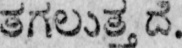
ತಗಲುತ್ತದೆ.
